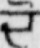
ਦੋ
